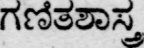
ಗಣಿತಶಾಸ್ತ್ರ
